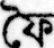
ফৈ
